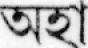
অহা
